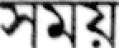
সময়
